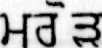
ਮਰੋੜ
